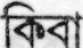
কিবা
